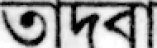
তাদবা
